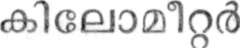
കിലോമീറ്റര്‍
